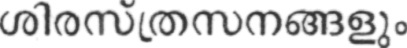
ശിരസ്ത്രസനങ്ങളും
